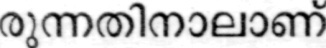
രുന്നതിനാലാണ്
